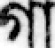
গা
